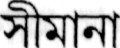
সীমানা
